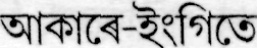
আকাৰে-ইংগিতে
